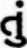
તું
